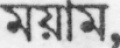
ময়াম,
